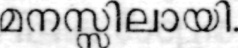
മനസ്സിലായി.
